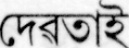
দেৱতাই
